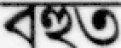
বহুত
